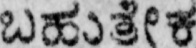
ಬಹುತೇಕ
